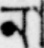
না
